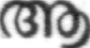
ആ
